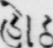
હોઠ
